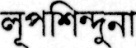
লূপশিন্দুনা
